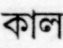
কাল
